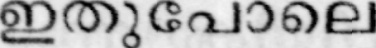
ഇതുപോലെ
